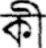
কী
